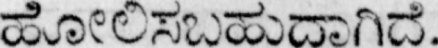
ಹೋಲಿಸಬಹುದಾಗಿದೆ.
